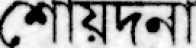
শোয়দনা
